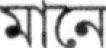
মানে
